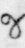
જ
